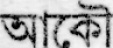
আকৌ
